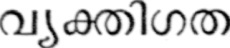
വ്യക്തിഗത
